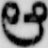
ಆ
